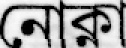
নোক্না
